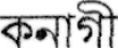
কনাগী
